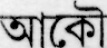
আকৌ
